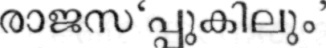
രാജസ'പ്പുകിലും'
